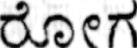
ರೋಗ
